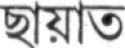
ছায়াত
